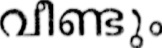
വീണ്ടും
